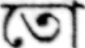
তো
